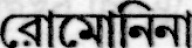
রোমোনিনা
